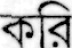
করি
